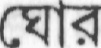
ঘোর
